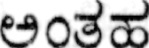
ಅಂತಹ
